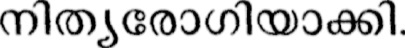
നിത്യരോഗിയാക്കി.
